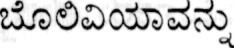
ಬೊಲಿವಿಯಾವನ್ನು
